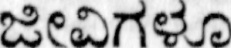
ಜೀವಿಗಳೂ
